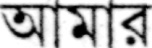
আমার
